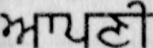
ਆਪਣੀ
